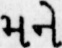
મને
